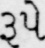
રૂપે
